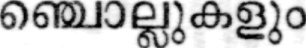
ഞ്ചൊല്ലുകളും
